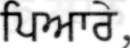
ਪਿਆਰੇ,
